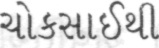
ચોક્સાઈથી
